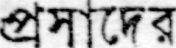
প্রসাদের
